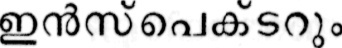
ഇന്‍സ്പെക്ടറും
